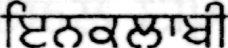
ਇਨਕਲਾਬੀ
